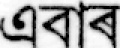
এবাৰ
